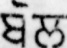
ਬੋਲ
